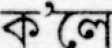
ক'লে
